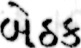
બેઠક
